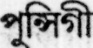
পুন্সিগী
